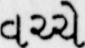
વચ્ચે
